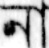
না
